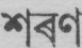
শৰণ
